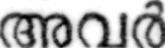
അവര്‍
